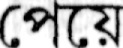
পেয়ে
